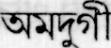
অমদুগী
